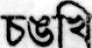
চঙখি
